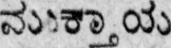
ಮುಕ್ತಾಯ
